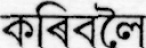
কৰিবলৈ
